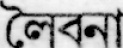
লৈবনা
